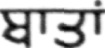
ਬਾਤਾਂ
